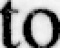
to
